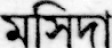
মসিদা
